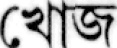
খোজ
